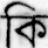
কি
